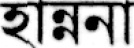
হান্ননা
